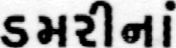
ડમરીનાં
